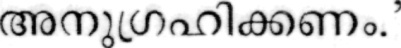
അനുഗ്രഹിക്കണം.'
